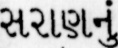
સરાણનું
